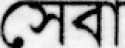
সেবা
